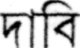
দাবি
